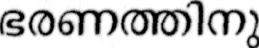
ഭരണത്തിനു
